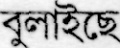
বুলাইছে
